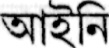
আইনি
